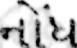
નોંધ
